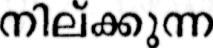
നില്ക്കുന്ന
